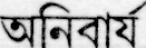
অনিবার্য
